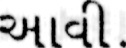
આવી.
